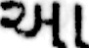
આ
